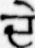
ਦੇ
